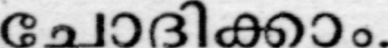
ചോദിക്കാം.
